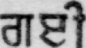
ਗਈ
